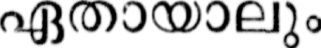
ഏതായാലും
